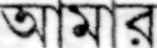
আমার
